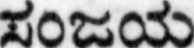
ಸಂಜಯ
